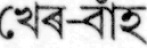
খেৰ-বাঁহ
